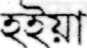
হইয়া
